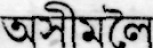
অসীমলৈ
